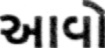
આવો
